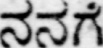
ನನಗೆ
